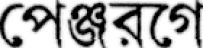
পেঞ্জরগে
